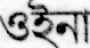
ওইনা
